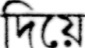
দিয়ে
